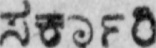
ಸರ್ಕಾರಿ
